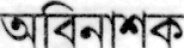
অবিনাশক
